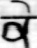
ਕੇ
